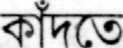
কাঁদতে
